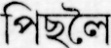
পিছলৈ
